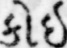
કોઈ
